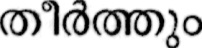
തീര്‍ത്തും
